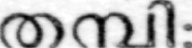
തമ്പി:
